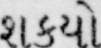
શક્યો
